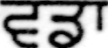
ਵਡਾ
